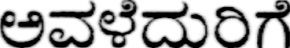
ಅವಳೆದುರಿಗೆ
